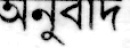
অনুবাদ
